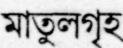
মাতুলগৃহ
